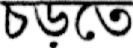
চড়তে
